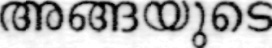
അങ്ങയുടെ
